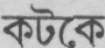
কটকে
